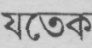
যতেক
